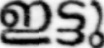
ഇട്ടു
